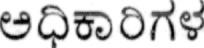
ಅಧಿಕಾರಿಗಳ
